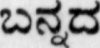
ಬನ್ನದ
